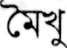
মৈখু
